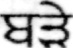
ਬੜੇ
